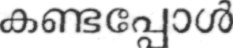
കണ്ടപ്പോള്‍
